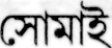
সোমাই
